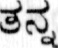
ತನ್ನ
